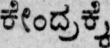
ಕೇಂದ್ರಕ್ಕೆ
